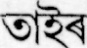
তাইৰ
